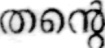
തന്റെ
